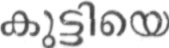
കുട്ടിയെ
